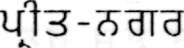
ਪ੍ਰੀਤ-ਨਗਰ
